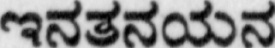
ಇನತನಯನ
